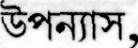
উপন্যাস,
